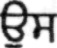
ਉਸ
